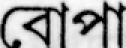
বোপা
